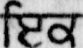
ਇਕ
